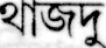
থাজদু
